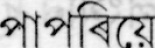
পাপৰিয়ে
